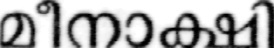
മീനാക്ഷി
